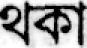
থকা
